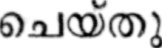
ചെയ്തു
